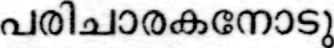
പരിചാരകനോടു
